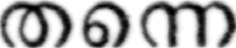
തന്നെ
